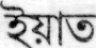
ইয়াত
